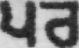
ਪਰ
